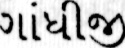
ગાંધીજી
